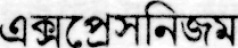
এক্সপ্রেসনিজম
